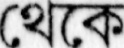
থেকে
